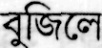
বুজিলে
